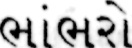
ભાંભરો
